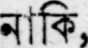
নাকি,
